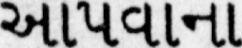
આપવાના
